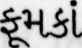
ફૂમકાં
